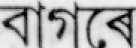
বাগৰে
